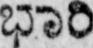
ಭಾರಿ
